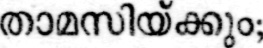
താമസിയ്ക്കും;
